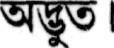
অদ্ভুত।
